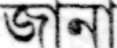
জানা
